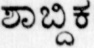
ಶಾಬ್ದಿಕ
